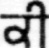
ਕੀ
